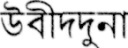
উবীদদুনা
